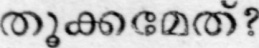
തൂക്കമേത്?
